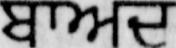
ਬਾਅਦ
